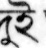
দুই
